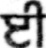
ਈ
